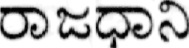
ರಾಜಧಾನಿ
